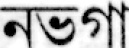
নভগা
